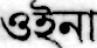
ওইনা
